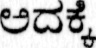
ಅದಕ್ಕೆ
